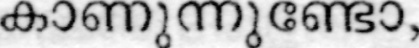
കാണുന്നുണ്ടോ,
